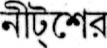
নীট্‌শের
